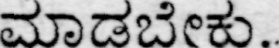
ಮಾಡಬೇಕು.
